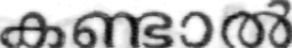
കണ്ടാല്‍
